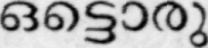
ഒട്ടൊരു
